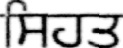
ਸਿਹਤ
